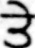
ਤੇ
